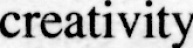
creativity
